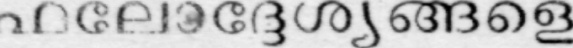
ഫലോദ്ദേശ്യങ്ങളെ
